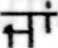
ਜਾਂ
